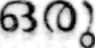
ഒരു
